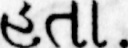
હતા.
